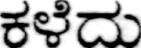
ಕಳೆದು
